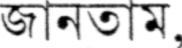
জানতাম,
